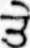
ਤੇ
